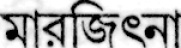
মারজিৎনা
